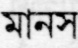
মানস
